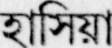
হাসিয়া
